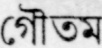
গৌতম
